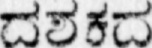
ದಶಕದ
